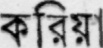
করিয়া
